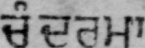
ਚੰਦਰਮਾ
